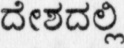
ದೇಶದಲ್ಲಿ
